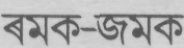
ৰমক-জমক
